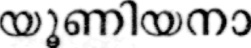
യൂണിയനാ
